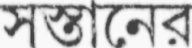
সস্তানের
